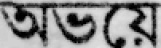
অভয়ে
